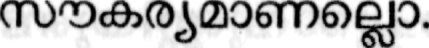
സൌകര്യമാണല്ലൊ.
